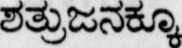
ಶತ್ರುಜನಕ್ಕೂ
